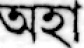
অহা
